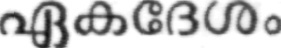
ഏകദേശം
